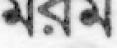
মরম
